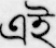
এই
